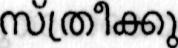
സ്ത്രീക്കു
